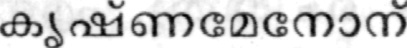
കൃഷ്ണമേനോന്
